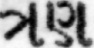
ત્રણ
